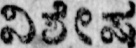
ವಿಶೇಷ
